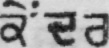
ਕੇਂਦਰ
